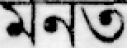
মনত
